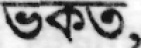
ভকত,
